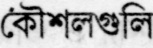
কৌশলগুলি
